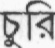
চুরি
